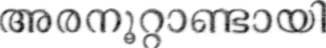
അരനൂറ്റാണ്ടായി
